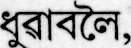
ধুৱাবলৈ,
